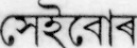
সেইবোৰ
